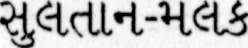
સુલતાન-મલક
